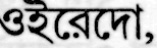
ওইরেদো,
